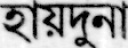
হায়দুনা
